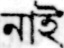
নাই
